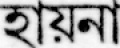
হায়না
